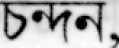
চন্দন,
